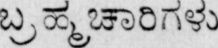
ಬ್ರಹ್ಮಚಾರಿಗಳು
